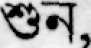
শুন,
